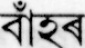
বাঁহৰ
